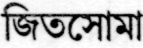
জিতসোমা
